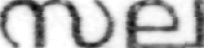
സല
